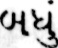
બધું
